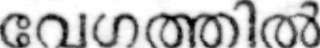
വേഗത്തില്‍
